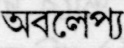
অবলেপ্য
